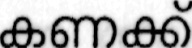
കണക്ക്
